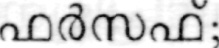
ഫര്‍സഫ്;
